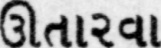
ઊતારવા
